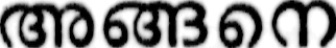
അങ്ങനെ
